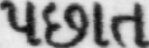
પછાત
